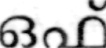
ഒഫ്
